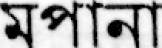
মপানা
